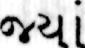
જ્યાં
